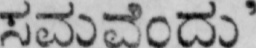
ಸಮವೆಂದು’
